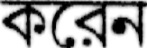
করেন
